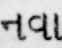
નવા
